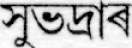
সুভদ্রাৰ
